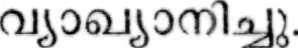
വ്യാഖ്യാനിച്ചു.
